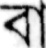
বা
